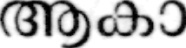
ആകാ
